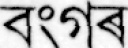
বংগৰ
